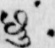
છું.
